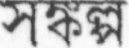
সঙ্কল্প
